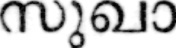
സുഖാ
